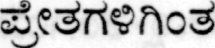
ಪ್ರೇತಗಳಿಗಿಂತ
